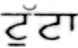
ਟੁੱਟਾ
